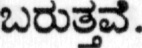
ಬರುತ್ತವೆ.
